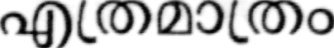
എത്രമാത്രം
